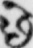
છે
